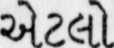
એટલો
